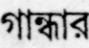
গান্ধার
